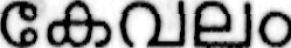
കേവലം
